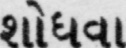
શોધવા
